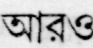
আরও
